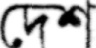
দেশ
